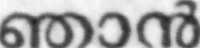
ഞാന്‍
